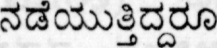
ನಡೆಯುತ್ತಿದ್ದರೂ
